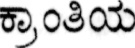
ಕ್ರಾಂತಿಯ
